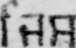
ਜਿਸ
